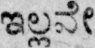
ಇಲ್ಲವೇ
